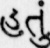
હતું
